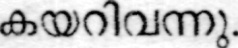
കയറിവന്നു.
